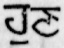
ਹੁਣ
